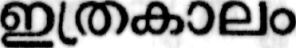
ഇത്രകാലം
